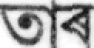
তাৰ
